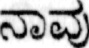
ನಾವು
